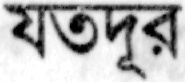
যতদূর
